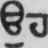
ਉਹ
